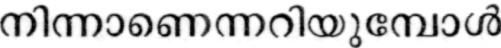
നിന്നാണെന്നറിയുമ്പോള്‍
